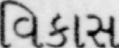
વિકાસ
